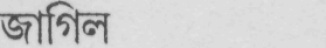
জাগিল
